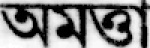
অমত্তা
